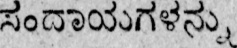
ಸಂದಾಯಗಳನ್ನು
